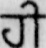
ਹੀ
